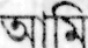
আমি
